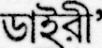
ডাইরী’
